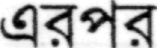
এরপর
